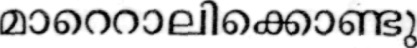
മാറെറാലിക്കൊണ്ടു
